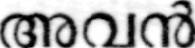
അവന്‍
